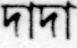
দাদা
